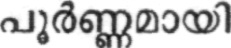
പൂര്‍ണ്ണമായി
